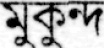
মুকুন্দ
